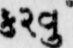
કરવું
